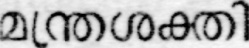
മന്ത്രശക്തി
